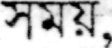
সময়,
